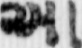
આ
